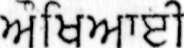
ਔਖਿਆਈ
